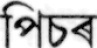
পিচৰ
